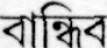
বান্ধিব
